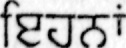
ਇਹਨਾਂ
